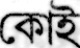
কৌই
